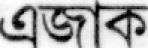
এজাক
